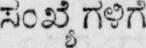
ಸಂಖ್ಯೆಗಳಿಗೆ
